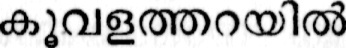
കൂവളത്തറയില്‍
